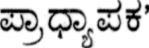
ಪ್ರಾಧ್ಯಾಪಕ’
